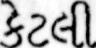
કેટલી
